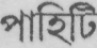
পাহিটি
